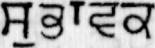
ਸੁਭਾਵਕ
